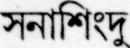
সনাশিংদু
